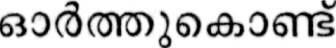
ഓര്‍ത്തുകൊണ്ട്
